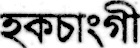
হকচাংগী
